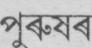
পুৰুষৰ
